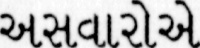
અસવારોએ
